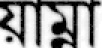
য়াম্না
